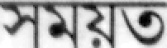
সময়ত
